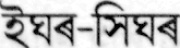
ইঘৰ-সিঘৰ
